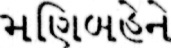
મણિબહેને
